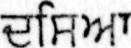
ਦਸਿਆ
